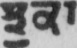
ਝੁਕਾ
